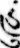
હું
